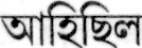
আহিছিল
